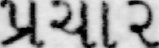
પ્રચાર
